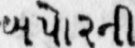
બપોરની
